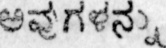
ಅವುಗಳನ್ನು
